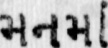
મનમાં
